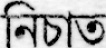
নিচাত
